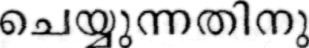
ചെയ്യുന്നതിനു
